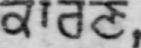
ਕਾਰਣ,
